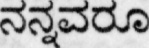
ನನ್ನವರೂ
